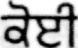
ਕੋਈ
